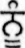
ਨੂੰ
